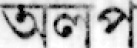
অলপ
